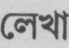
লেখা
